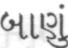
બાણું
